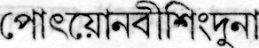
পোৎয়োনবীশিংদুনা
